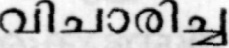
വിചാരിച്ച
